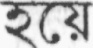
হয়ে
